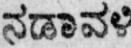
ನಡಾವಳಿ
